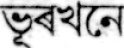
ভূৰখনে
